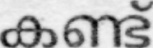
കണ്ട്
